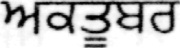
ਅਕਤੂਬਰ
